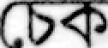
চেক
